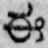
ಈ
